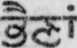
ਭੈਣਾਂ
